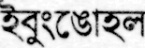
ইবুংঙোহল
